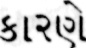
કારણે
